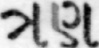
ત્રણ
